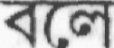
বলে
